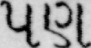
પણ
